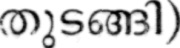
തുടങ്ങി)
